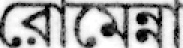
রোমেন্না
